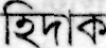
হিদাক
